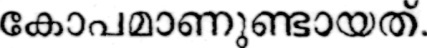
കോപമാണുണ്ടായത്.
